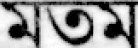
মতম
